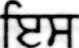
ਇਸ
